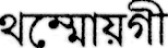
থম্মোয়গী
